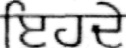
ਇਹਦੇ
